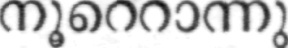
നൂറെറാന്നു
